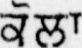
ਕੋਲਾ
